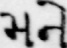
મને
